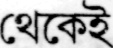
থেকেই
